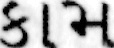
કામ
